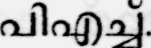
പിഎച്ച്.
